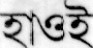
হাওই
